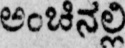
ಅಂಚಿನಲ್ಲಿ
